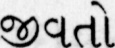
જીવતો
